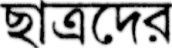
ছাত্রদের
